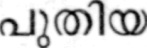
പുതിയ
